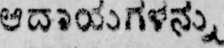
ಆದಾಯಗಳನ್ನು
